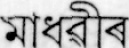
মাধৱীৰ
